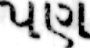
પણ
